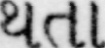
થતા
